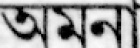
অমনা
